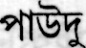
পাউদু
